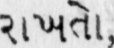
રાખતો,
